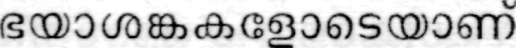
ഭയാശങ്കകളോടെയാണ്
